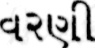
વરણી
